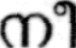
നീ
